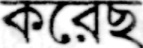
করেছ
